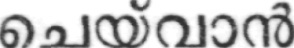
ചെയ്വാന്‍
